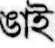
ঙাই
